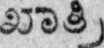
ಖಾತ್ರಿ
